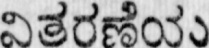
ವಿತರಣೆಯ
